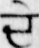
ਦੇ
